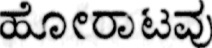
ಹೋರಾಟವು
